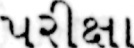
પરીક્ષા
